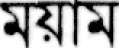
ময়াম
